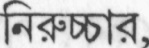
নিরুচ্চার,
